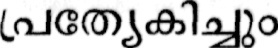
പ്രത്യേകിച്ചും
